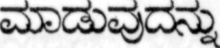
ಮಾಡುವುದನ್ನು
